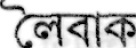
লৈবাক
